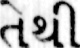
તેથી
